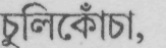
চুলিকোঁচা,
